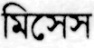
মিসেস
